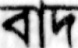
বাদ
